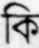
কি
